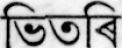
ভিতৰি
